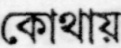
কোথায়
